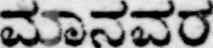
ಮಾನವರ
